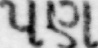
પણ
